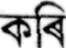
কৰি
